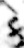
કે
